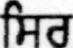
ਸਿਰ
